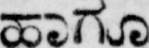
ಹಾಗೂ
